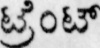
ಟ್ರೆಂಟ್
